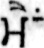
ਮੈਂ
